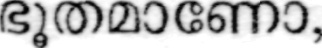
ഭൂതമാണോ,
